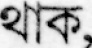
থাক,
